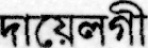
দায়েলগী
